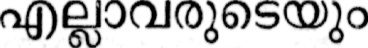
എല്ലാവരുടെയും
